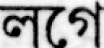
লগে
